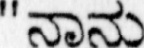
“ನಾನು
